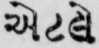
એટલે
